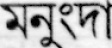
মনুংদা
